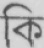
কি
